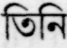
তিনি
